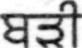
ਬੜੀ
